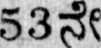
53ನೇ
